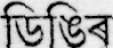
ডিঙিৰ
